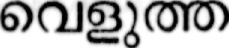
വെളുത്ത
